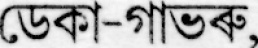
ডেকা-গাভৰু,
